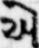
એ
